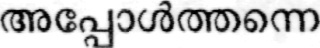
അപ്പോള്‍ത്തന്നെ
